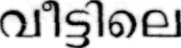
വീട്ടിലെ
